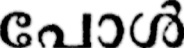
പോള്‍
